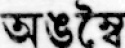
অঙম্বৈ
